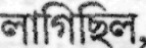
লাগিছিল,
